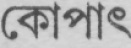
কোপাৎ
